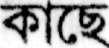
কাছে
